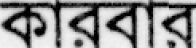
কারবার
